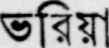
ভরিয়া
